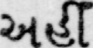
અહીં
